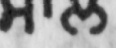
ਸਾਲ
